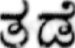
ತಡೆ
